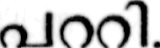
പററി.
